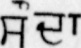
ਸੌਦਾ
